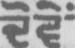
ਦੋਵੇਂ
